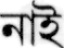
নাই
